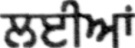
ਲਈਆਂ
